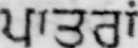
ਪਾਤਰਾਂ
